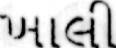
ખાલી
